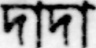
দাদা
